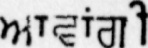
ਆਵਾਂਗੀ
